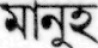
মানুহ
